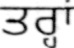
ਤਰ੍ਹਾਂ
